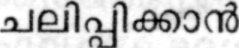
ചലിപ്പിക്കാന്‍
